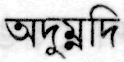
অদুম্নদি
